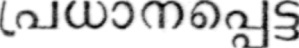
പ്രധാനപ്പെട്ട
